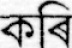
কৰি
